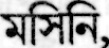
মসিনি,
